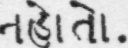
નહોતો.
